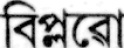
বিপ্লৱো
